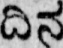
ದಿನ
